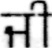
ਜੀ
